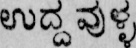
ಉದ್ದವುಳ್ಳ
